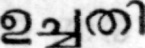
ഉച്ചതി
